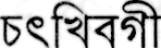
চৎখিবগী
